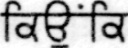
ਕਿਉਂਕਿ
